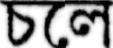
চলে
